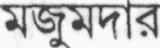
মজুমদার
